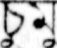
চুমু
